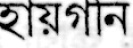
হায়গনি
